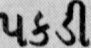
પકડી
